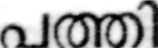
പത്തി
